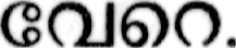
വേറെ.
